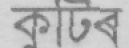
কুটিৰ
